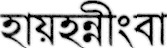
হায়হন্নীংবা
